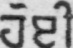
ਹੋਈ
